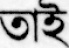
তাই
